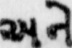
અને
